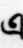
এ
